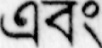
এবং
